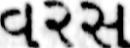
વરસ
